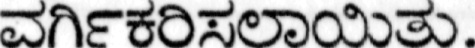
ವರ್ಗಿಕರಿಸಲಾಯಿತು.
